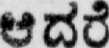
ಆದರೆ
